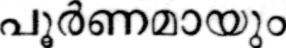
പൂര്‍ണമായും
